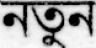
নতুন
